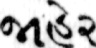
જાહેર
